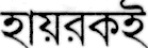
হায়রকই
